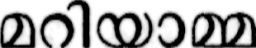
മറിയാമ്മ
